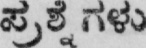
ಪ್ರಶ್ನೆಗಳು
